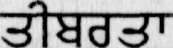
ਤੀਬਰਤਾ
